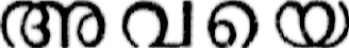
അവയെ
